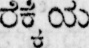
ರೆಕ್ಕೆಯ
